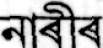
নাৰীৰ
